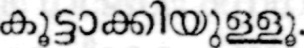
കൂട്ടാക്കിയുള്ളൂ.
